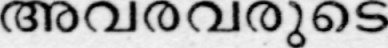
അവരവരുടെ
